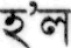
হ'ল
